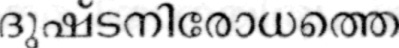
ദുഷ്ടനിരോധത്തെ
